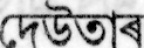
দেউতাৰ
